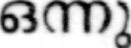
ഒന്നു
